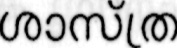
ശാസ്ത്ര
